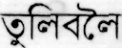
তুলিবলৈ
